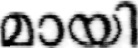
മായി
